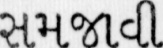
સમજાવી
